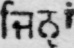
ਜਿਨ੍ਹਾਂ
